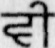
ਵੀ
